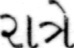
રાત્રે
